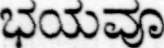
ಭಯವೂ
